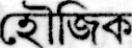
হৌজিক
